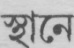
স্থানে
